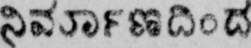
ನಿರ್ಮಾಣದಿಂದ
